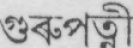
গুৰুপত্নী
